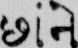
છાંને
